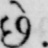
છે.
